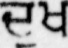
ਦੁਖ
